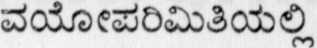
ವಯೋಪರಿಮಿತಿಯಲ್ಲಿ
